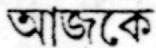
আজকে
